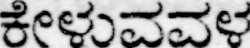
ಕೇಳುವವಳ
